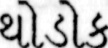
થોડોક
